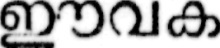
ഈവക
